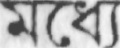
মধ্যে
